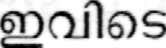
ഇവിടെ
